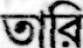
তারি
